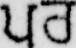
ਪਰ
